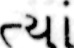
ત્યાં
